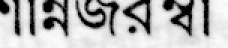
শান্নজরম্বা
